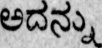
ಅದನ್ನು
